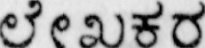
ಲೇಖಕರ
